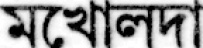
মখোলদা
